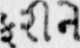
ફરીને
